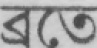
ব্ৰতে
